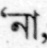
‘না,
